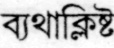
ব্যথাক্লিষ্ট
